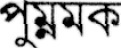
পুম্নমক
